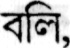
বলি,
